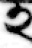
হ
